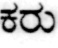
ಕರು
